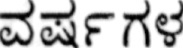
ವರ್ಷಗಳ
